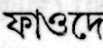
ফাওদে
